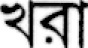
খরা
